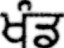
ਖੰਡ
